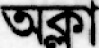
অক্লা
